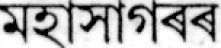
মহাসাগৰৰ
